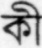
কী
